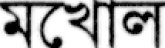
মখোল
